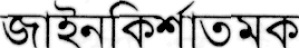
জাইনকির্শাতমক
